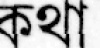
কথা
